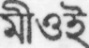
মীওই
